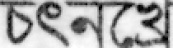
চৎনখ্রে
